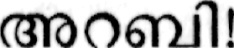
അറബി!
